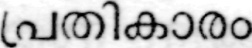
പ്രതികാരം
